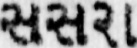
સસરા
